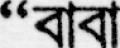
“বাবা
